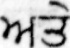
ਅਤੇ
